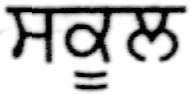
ਸਕੂਲ
